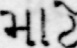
માટે
